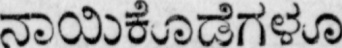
ನಾಯಿಕೊಡೆಗಳೂ
